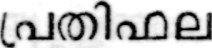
പ്രതിഫല
